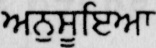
ਅਨੁਸੂਇਆ
